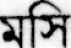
মসি
